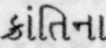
ક્રાંતિના
